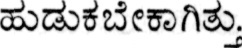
ಹುಡುಕಬೇಕಾಗಿತ್ತು.
